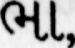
ભા,
